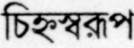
চিহ্নস্বরূপ
